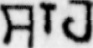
ਸਾਹ
